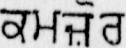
ਕਮਜ਼ੋਰ
